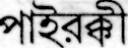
পাইরক্কী
